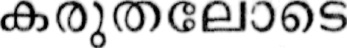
കരുതലോടെ
